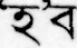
'হ'ব
